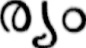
ര്യം
